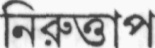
নিরুত্তাপ
